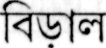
বিড়াল
